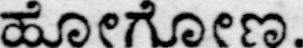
ಹೋಗೋಣ.
